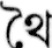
থৈ
